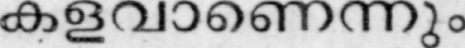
കളവാണെന്നും
